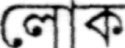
লোক
